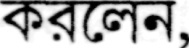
করলেন,
